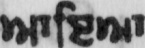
ਆਇਆ
